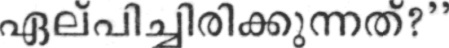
ഏല്പിച്ചിരിക്കുന്നത്?"
